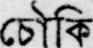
চৌকি
